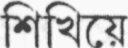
শিখিয়ে
